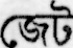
জেট
